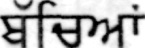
ਬੱਚਿਆਂ
